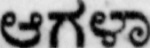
ಆಗಳಾ
